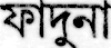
ফাদুনা
